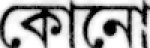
কোনো
